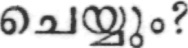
ചെയ്യും?
